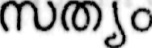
സത്യം
